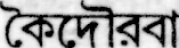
কৈদৌরবা
